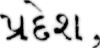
પ્રદેશ,
